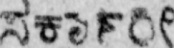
ಸರ್ಕಾರೀ
